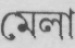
মেলা
